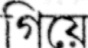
গিয়ে
